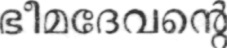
ഭീമദേവന്റെ
